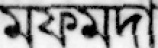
মফমদা
